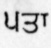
ਪਤਾ
